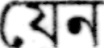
যেন
